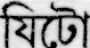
যিটো
